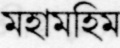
মহামহিম
